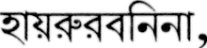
হায়রুরবনিনা,
